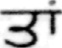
ਤਾਂ
